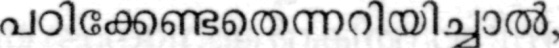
പഠിക്കേണ്ടതെന്നറിയിച്ചാല്‍,
